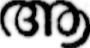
ആ
